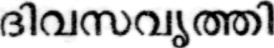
ദിവസവൃത്തി
